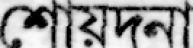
শোয়দনা
